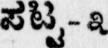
ಪಟ್ಟಿ-೩
